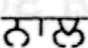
ਨਾਲ
